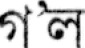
গ'ল
